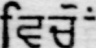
ਵਿਚੋਂ
